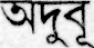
অদূবূ
